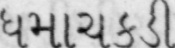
ધમાચકડી
